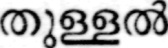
തുള്ളല്‍
